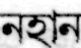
নহান
